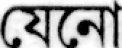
যেনো
